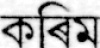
কৰিম
